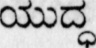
ಯುದ್ಧ
